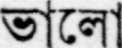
ভালো
